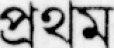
প্রথম
